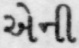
એની
